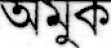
অমুক
